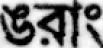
ঙরাং
